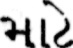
માટે
